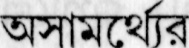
অসামর্থ্যের
